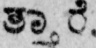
ತ್ತಾರೆ.
